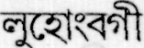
লুহোংবগী
